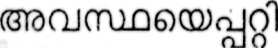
അവസ്ഥയെപ്പറ്റി
